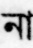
না
